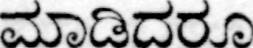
ಮಾಡಿದರೂ
